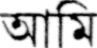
আমি
